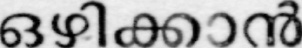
ഒഴിക്കാന്‍
